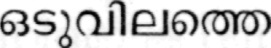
ഒടുവിലത്തെ
